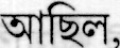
আছিল,
